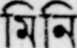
মিনি
